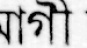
মাগী
